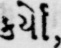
કર્યો,
